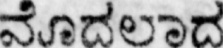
ಮೊದಲಾದ
